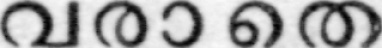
വരാതെ
